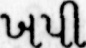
ખપી
